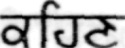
ਕਹਿਣ
